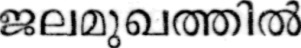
ജലമുഖത്തില്‍
